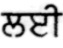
ਲਈ
